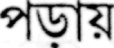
পড়ায়
